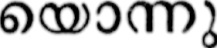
യൊന്നു
